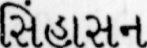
સિંહાસન
